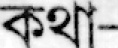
কথা-
